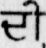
ਦੀ
